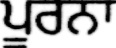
ਪੂਰਨਾ
